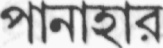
পানাহার
